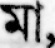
মা,
